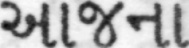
આજના
